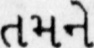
તમને
